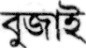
বুজাই
